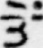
ਤੋਂ
